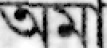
অমা
